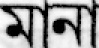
মানা
